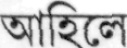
আহিলে
